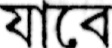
যাবে
